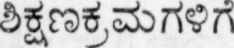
ಶಿಕ್ಷಣಕ್ರಮಗಳಿಗೆ
